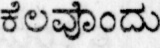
ಕೆಲವೊಂದು
